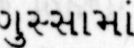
ગુસ્સામાં
